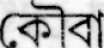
কৌবা
